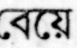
বেয়ে
